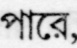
পারে,
